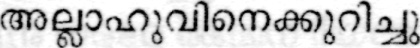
അല്ലാഹുവിനെക്കുറിച്ചു
